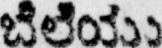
ಬೆಲೆಯು
